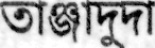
তাঞ্জাদুদা
